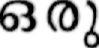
ഒരു
